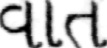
વાત
